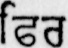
ਫਿਰ
